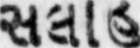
સલાહ
